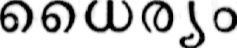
ധൈര്യം
